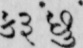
કરૂંછું
